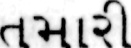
તમારી
